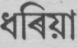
ধৰিয়া
